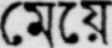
মেয়ে
